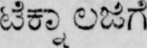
ಟೆಕ್ನಾಲಜಿಗೆ
